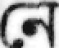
নে
